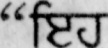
''ਇਹ
